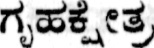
ಗೃಹಕ್ಷೇತ್ರ
